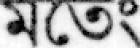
মতেং
